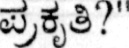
ಪ್ರಕೃತಿ?”
